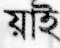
য়াই
